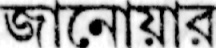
জানোয়ার
